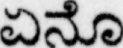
ಏನೊ
